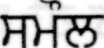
ਸਮੌਲ
